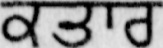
ਕਤਾਰ
